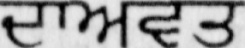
ਦਾਅਵਤ
